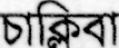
চাক্লিবা
